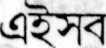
এইসব
